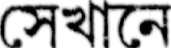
সেখানে
